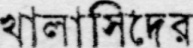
খালাসিদের
